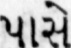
પાસે
